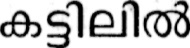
കട്ടിലില്‍
